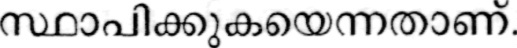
സ്ഥാപിക്കുകയെന്നതാണ്.
